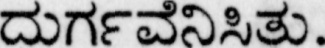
ದುರ್ಗವೆನಿಸಿತು.
